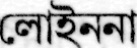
লোইননা
